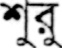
শুরু
